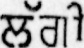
ਲੱਗੀ
